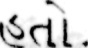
હતો.
